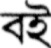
বই
